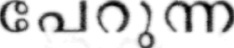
പേറുന്ന
